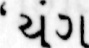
'યંગ
